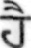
ਹੈ
